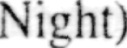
Night)
